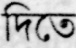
দিতে
